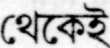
থেকেই
